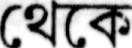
থেকে
